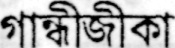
গান্ধীজীকা
